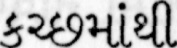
કચ્છમાંથી
